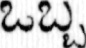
ಒಬ್ಬ
